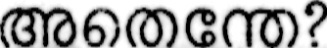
അതെന്തേ?
